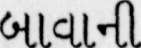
બાવાની
